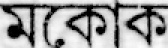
মকোক
